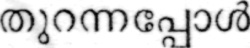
തുറന്നപ്പോള്‍
